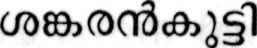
ശങ്കരന്‍കുട്ടി
